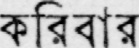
করিবার
